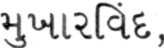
મુખારવિંદ,
